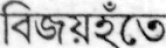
বিজয়হঁতে
